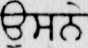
ਉਸਨੇ
